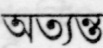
অত্যন্ত
